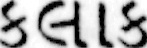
કલાક
